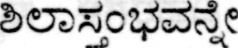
ಶಿಲಾಸ್ತಂಭವನ್ನೇ
